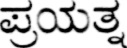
ಪ್ರಯತ್ನ
